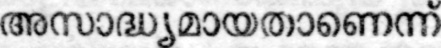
അസാദ്ധ്യമായതാണെന്ന്
